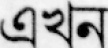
এখন
